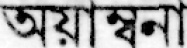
অয়াম্বনা
